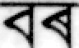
বৰ
